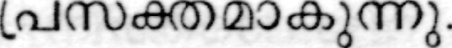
പ്രസക്തമാകുന്നു.
